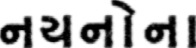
નયનોના
